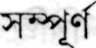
সম্পূর্ণ
